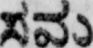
ಸಮ
